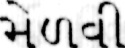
મેળવી
